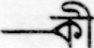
–কী
